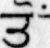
ਤੋਂ
